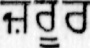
ਜ਼ਰੂਰ
